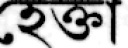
হেক্তা
